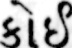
કોઈ
